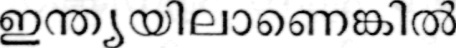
ഇന്ത്യയിലാണെങ്കില്‍
